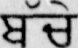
ਬੱਚੇ
